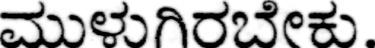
ಮುಳುಗಿರಬೇಕು.
